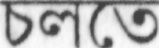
চলতে
